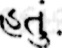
હતું.
